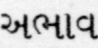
અભાવ
